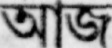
আজ
